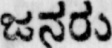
ಜನರು
